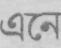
এনে
